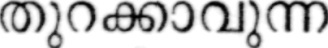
തുറക്കാവുന്ന
